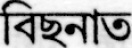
বিছনাত
